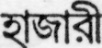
হাজারী
